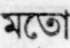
মতো
